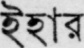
ইহার
